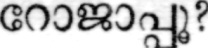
റോജാപ്പൂ?
